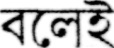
বলেই
